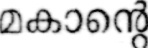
മകാന്റെ
